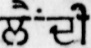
ਲੈਂਦੀ
